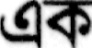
এক
